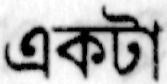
একটা
